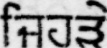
ਜਿਹੜੇ
